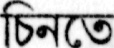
চিনতে
